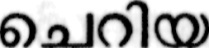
ചെറിയ
